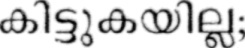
കിട്ടുകയില്ല;
